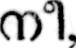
നീ,
